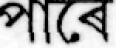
পাৰে
